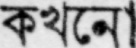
কখনো
